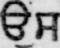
ਉਸ
